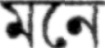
মনে
